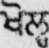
ਖੋਲ੍ਹ
